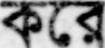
করে
